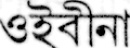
ওইবীনা
